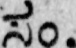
ಸಂ.
